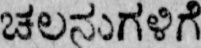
ಚಲನುಗಳಿಗೆ
